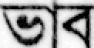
ভাব
